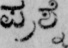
ಪ್ರಶ್ನೆ
